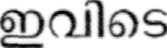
ഇവിടെ
